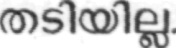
തടിയില്ല.
